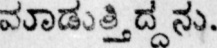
ಮಾಡುತ್ತಿದ್ದನು.
